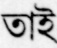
তাই
